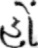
હોં
